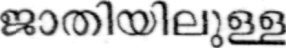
ജാതിയിലുള്ള
